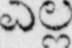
ಎಲ್ಲ
